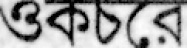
ওকচরে
